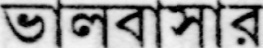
ভালবাসার
